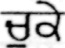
ਚੁਕੇ
